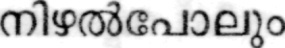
നിഴല്‍പോലും
